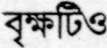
বৃক্ষটিও
